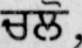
ਚਲੋ,
